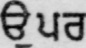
ਉਪਰ
